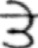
ਤੇ
